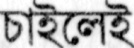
চাইলেই
